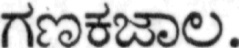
ಗಣಕಜಾಲ.
